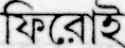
ফিরোই
